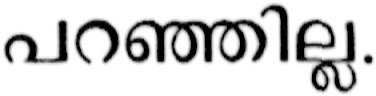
പറഞ്ഞില്ല.
